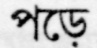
পড়ে
